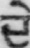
ਦੇ
